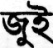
জুই
